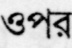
ওপর
